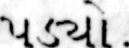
પડ્યો.
